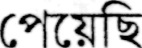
পেয়েছি
